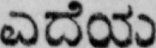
ಎದೆಯ
